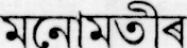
মনোমতীৰ
